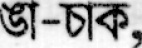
ঙা-চাক,
